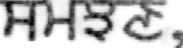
ਸਮਝਣ,
